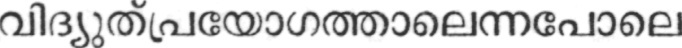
വിദ്യുത്പ്രയോഗത്താലെന്നപോലെ
